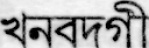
খনবদগী
